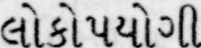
લોકોપયોગી
